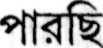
পারছি
